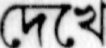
দেখে
